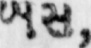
બસ,
